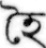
হৈ
